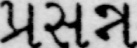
પ્રસન્ન
